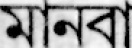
মানবা
